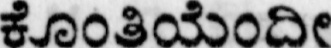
ಕೊಂತಿಯೆಂದೀ
